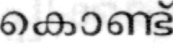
കൊണ്ട്
